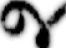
જ
